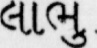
લાભુ
